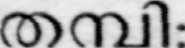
തമ്പി:
